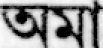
অমা
